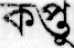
কপ্তু
